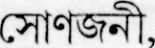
সোণজনী,
